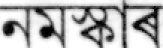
নমস্কাৰ
